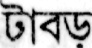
টাবড়
